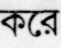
করে
